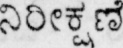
ನಿರೀಕ್ಷಣೆ
